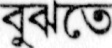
বুঝতে
